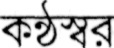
কন্ঠস্বর
